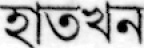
হাতখন
